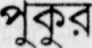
পুকুর
